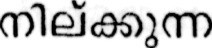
നില്ക്കുന്ന
